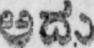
ಅದು
